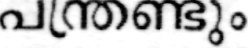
പന്ത്രണ്ടും
